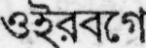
ওইরবগে
